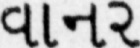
વાનર
